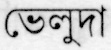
ভেলুদা
